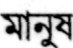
মানুষ
